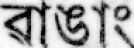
ৱাঙাং
